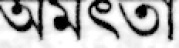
অমৎতা
